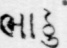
ભાઠું
